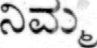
ನಿಮ್ಮ
